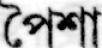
পৈশা
